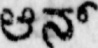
ಆನ್
